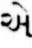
એ
